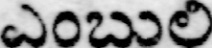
ಎಂಬುಲಿ
